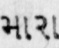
મારા
